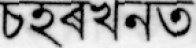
চহৰখনত
